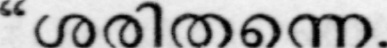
"ശരിതന്നെ.
